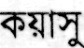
কয়াসু
